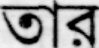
তার
